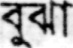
বুঝা
